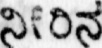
ನೀರಿನ
